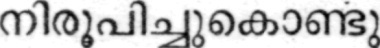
നിരൂപിച്ചുകൊണ്ടു
